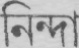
নিন্দা
